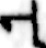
ન
